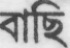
বাছি
